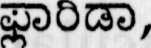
ಪ್ಲಾರಿಡಾ,
